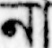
না
